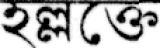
হল্লক্তে
